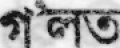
গ'লত
